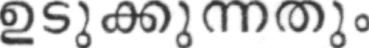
ഉടുക്കുന്നതും
